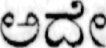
ಅದೇ
